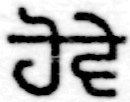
ਹੋਵੇ
